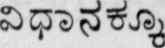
ವಿಧಾನಕ್ಕೂ
